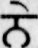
ਨੇ
